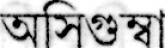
অসিগুম্বা
